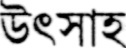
উত্সাহ
